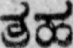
ತಹ
